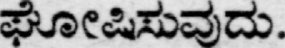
ಘೋಷಿಸುವುದು.
